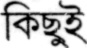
কিছুই
